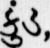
કુંડ,
